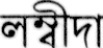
লম্বীদা
